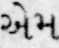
એમ
